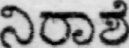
ನಿರಾಶೆ
